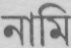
নামি
